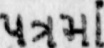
પત્રમાં
